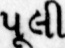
પૂલી
